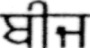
ਬੀਜ
